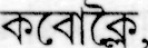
কবোক্লৈ,
